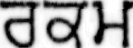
ਰਕਮ
